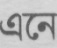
এনে
